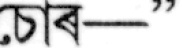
চোৰ-"
